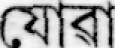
যোৱা
